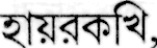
হায়রকখি,
